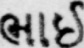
ભાઈ
